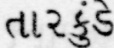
તારકુંડે
